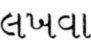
લખવા
